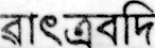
ৱাৎত্রবদি
